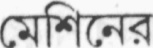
মেশিনের
